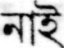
নাই
